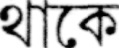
থাকে
